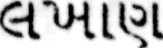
લખાણ
